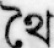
থৈ
